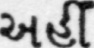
અહીં
